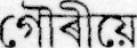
গৌৰীয়ে
